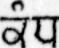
ਕੰਧ
